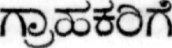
ಗ್ರಾಹಕರಿಗೆ
